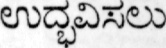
ಉದ್ಭವಿಸಲು
